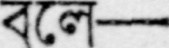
বলে—
